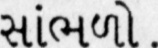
સાંભળો.
